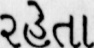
રહેતા
